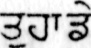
ਤੁਹਾਡੇ
